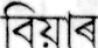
বিয়াৰ
